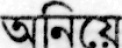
অনিয়ে
